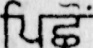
ਪਿਛੋਂ
